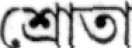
শ্রোতা
